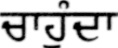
ਚਾਹੁੰਦਾ
